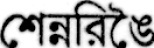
শেন্নরিঙৈ
